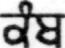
ਕੰਬ
